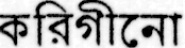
করিগীনো
